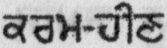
ਕਰਮ-ਹੀਣ
